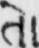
તો
